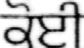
ਕੋਈ
